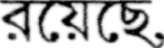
রয়েছে,
